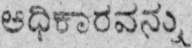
ಅಧಿಕಾರವನ್ನು
